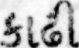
કાઢી
